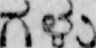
ಗಳು
